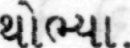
થોભ્યા.
